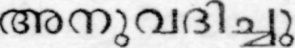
അനുവദിച്ചു
